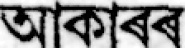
আকাৰৰ
